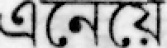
এনেয়ে
